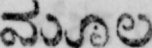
ಮೂಲ
